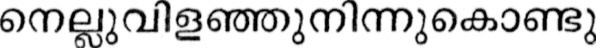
നെല്ലുവിളഞ്ഞുനിന്നുകൊണ്ടു
